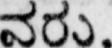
ವರು.
